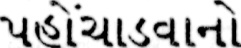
પહોંચાડવાનો
